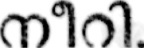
നീറി.
